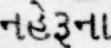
નહેરૂના
